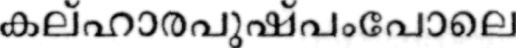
കല്ഹാരപുഷ്പംപോലെ
